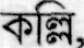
কল্লি,
